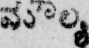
ಮೌಲ್ಯ
